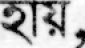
হায়,
